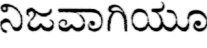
ನಿಜವಾಗಿಯೂ
